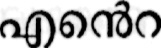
എന്റെ
